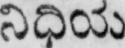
ನಿಧಿಯ
